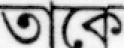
তাকে
